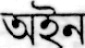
অইন
